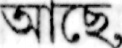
আছে,
